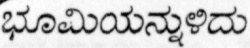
ಭೂಮಿಯನ್ನುಳಿದು
